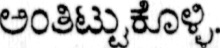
ಅಂತಿಟ್ಟುಕೊಳ್ಳಿ.
